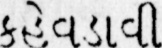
કહેવડાવી
